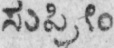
ಸುಪ್ರೀಂ
